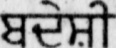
ਬਦੇਸ਼ੀ
